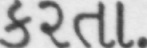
કરતા.
